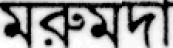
মরুমদা
